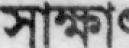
সাক্ষাৎ
